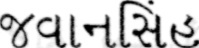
જવાનસિંહ
